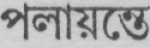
পলায়ন্তে
